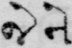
જેને
